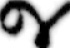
જ
